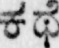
ಕಥೆ
